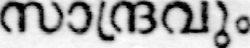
സാന്ദ്രവും
